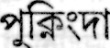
পুক্নিংদা
